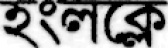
হংলক্লে
